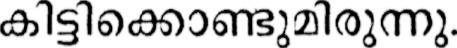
കിട്ടിക്കൊണ്ടുമിരുന്നു.
